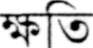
ক্ষতি
